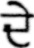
ਦੇ
